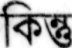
কিন্তু
